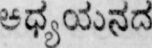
ಅಧ್ಯಯನದ
